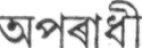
অপৰাধী
